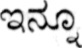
ಇನ್ನೂ
